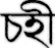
চহী
